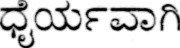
ಧೈರ್ಯವಾಗಿ
